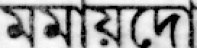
মমায়দো
